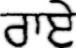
ਰਾਏ
